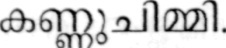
കണ്ണുചിമ്മി.
